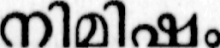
നിമിഷം
